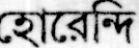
হোরেন্দি
